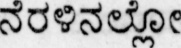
ನೆರಳಿನಲ್ಲೋ
